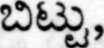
ಬಿಟ್ಟು,
